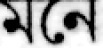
মনে
